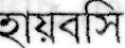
হায়বসি
